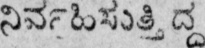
ನಿರ್ವಹಿಸುತ್ತಿದ್ದ
